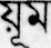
য়ূম
